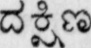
ದಕ್ಷಿಣ
